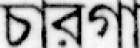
চারগা
